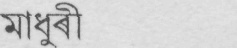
মাধুৰী
